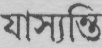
যাস্যন্তি
